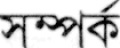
সম্পর্ক
